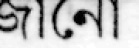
জানো
